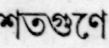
শতগুণে
